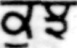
ਕੁਝ
